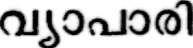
വ്യാപാരി
